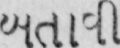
બતાવી
